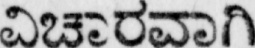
ವಿಚಾರವಾಗಿ
